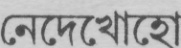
নেদেখোহো
